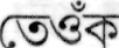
তেওঁক
